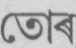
তোৰ
